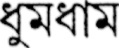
ধুমধাম
